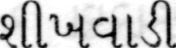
શીખવાડી
